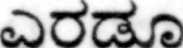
ಎರಡೂ
